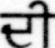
ਦੀ
